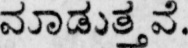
ಮಾಡುತ್ತವೆ.
